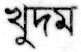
খুদম
